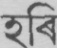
হৰি
